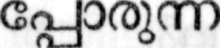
പ്പോരുന്ന
